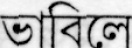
ভাবিলে
